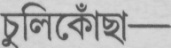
চুলিকোঁছা-
